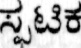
ಸ್ಫಟಿಕ
